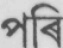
পৰি
